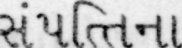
સંપત્તિના
